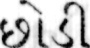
છોડી
